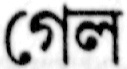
গেল
